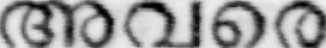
അവരെ
